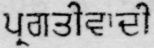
ਪ੍ਰਗਤੀਵਾਦੀ
